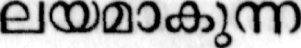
ലയമാകുന്ന
